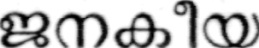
ജനകീയ
